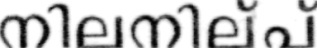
നിലനില്പ്
